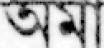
অমা
